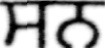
ਸਨ
